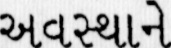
અવસ્થાને
